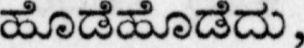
ಹೊಡೆಹೊಡೆದು,
